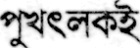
পুখৎলকই
